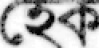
হেক
